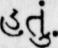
હતું.
